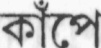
কাঁপে
